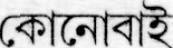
কোনোবাই
